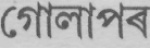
গোলাপৰ
